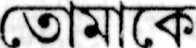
তোমাকে
